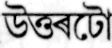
উত্তৰটো
